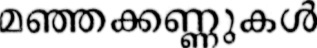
മഞ്ഞക്കണ്ണുകള്‍
